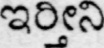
ಇರ್‍ತೀನಿ
